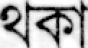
থকা
